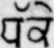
ਧੱਕੇ
